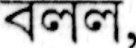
বলল,
